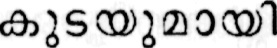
കുടയുമായി
